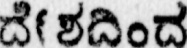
ದೇಶದಿಂದ
